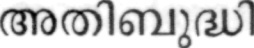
അതിബുദ്ധി
